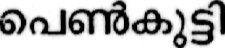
പെണ്‍കുട്ടി
